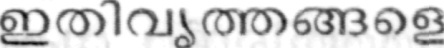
ഇതിവൃത്തങ്ങളെ
